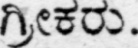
ಗ್ರೀಕರು.
